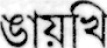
ঙায়খি
